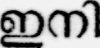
ഇനി
